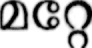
മറ്റേ
